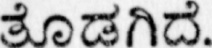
ತೊಡಗಿದೆ.
